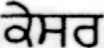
ਕੇਸਰ
